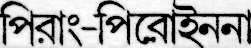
পিরাং-পিরোইননা
